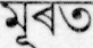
মূৰত
